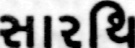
સારથિ
